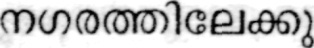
നഗരത്തിലേക്കു
